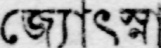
জ্যোৎস্না
